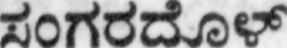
ಸಂಗರದೊಳ್
